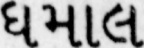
ધમાલ
